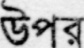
উপর
